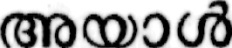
അയാള്‍
